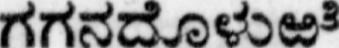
ಗಗನದೊಳುಱೆ
